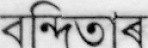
বন্দিতাৰ
